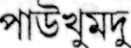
পাউখুমদু
